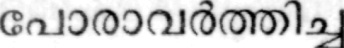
പോരാവര്‍ത്തിച്ച
